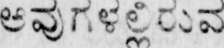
ಅವುಗಳಲ್ಲಿರುವ
